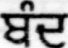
ਬੰਦ
